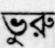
ভুরু
